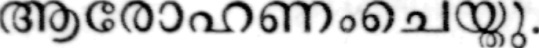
ആരോഹണംചെയ്തു.
